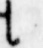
ન
